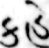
કહે
